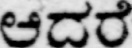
ಆದರೆ
